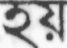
হয়
